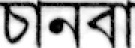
চানবা
